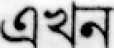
এখন
